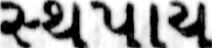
સ્થપાય
